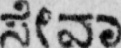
ಸೇವಾ
